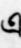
এ
